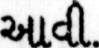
આવી.
